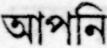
আপনি
